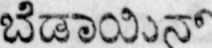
ಬೆಡಾಯಿನ್
